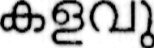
കളവു
